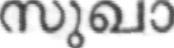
സുഖാ
